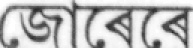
জোৰেৰে
